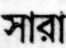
সারা
